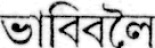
ভাবিবলৈ
